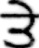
ਤੇ
